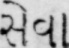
સેવા
